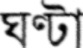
ঘণ্টা
